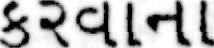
કરવાના
